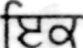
ਇਕ
